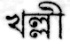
খল্লী
